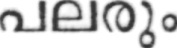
പലരും
